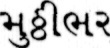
મુઠ્ઠીભર
